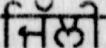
ਜਿੱਲੀ
